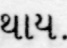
થાય.
